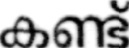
കണ്ട്
